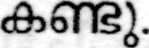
കണ്ടു.
